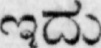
ಇದು
